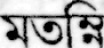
মতম্নি
